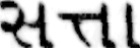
સત્તા
